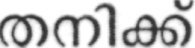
തനിക്ക്
